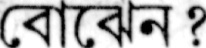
বোঝেন?
